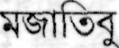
মজাতিবু
